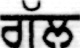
ਗੱਲ
